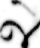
જે
